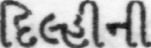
દિલ્હીની
